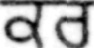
ਕਰ
